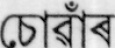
চোৱাঁৰ
